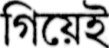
গিয়েই
